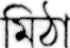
মিঠা
